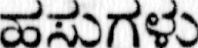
ಹಸುಗಳು
